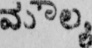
ಮೌಲ್ಯ
